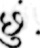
છું.
